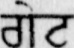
ਗੇਟ
